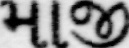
માજી
